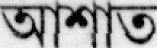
আশাত
